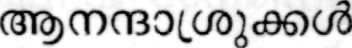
ആനന്ദാശ്രുക്കള്‍
